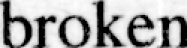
broken
